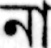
না
